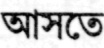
আসতে
